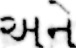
અને
